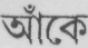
আঁকে
